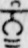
ਨੂੰ
